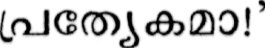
പ്രത്യേകമാ!'
